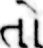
તો
